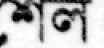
শেল
